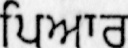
ਪਿਆਰ
